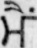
ਮੈਂ
